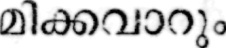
മിക്കവാറും
